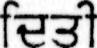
ਦਿਤੀ
